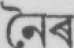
নৈৰ
